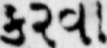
કરવા
